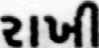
રાખી
